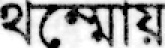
থম্মোয়
